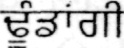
ਢੂੰਡਾਂਗੀ
